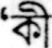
‘কী
